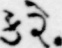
કરે.
